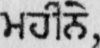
ਮਹੀਨੇ,
